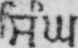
ਸਿੰਘ
